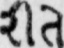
રીતે
